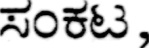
ಸಂಕಟ,
